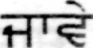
ਜਾਵੇ
